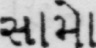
સામો
